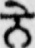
ਨੇ
